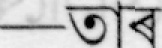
-তাৰ
